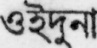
ওইদুনা
